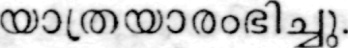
യാത്രയാരംഭിച്ചു.
